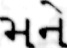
મને
